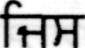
ਜਿਸ
